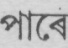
পাৰে
